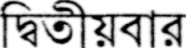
দ্বিতীয়বার
